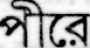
পীরে
